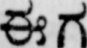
ಈಗ
